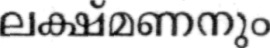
ലക്ഷ്മണനും
